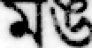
মঙ
